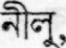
নীলু,
